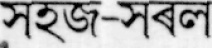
সহজ-সৰল
